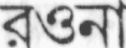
রওনা
